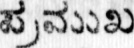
ಪ್ರಮುಖ
